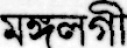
মাঙ্গলগী
